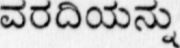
ವರದಿಯನ್ನು
